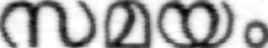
സമയം
